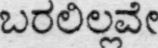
ಬರಲಿಲ್ಲವೇ
